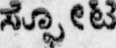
ಸ್ಫೋಟ
